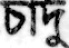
চাদু
